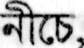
নীচে,
